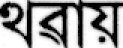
থৱায়
